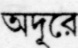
অদূরে
